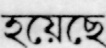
হয়েছে
